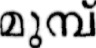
മുമ്പ്
